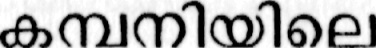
കമ്പനിയിലെ
